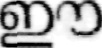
ഈ
